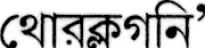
থোরক্লগনি’
